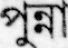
পুন্না
